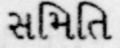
સમિતિ
